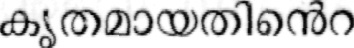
കൃതമായതിന്റെ
